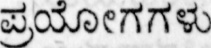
ಪ್ರಯೋಗಗಳು
